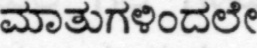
ಮಾತುಗಳಿಂದಲೇ
